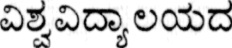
ವಿಶ್ವವಿದ್ಯಾಲಯದ
